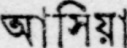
আসিয়া
